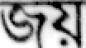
জয়
